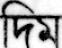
দিম
